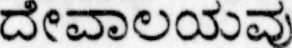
ದೇವಾಲಯವು
